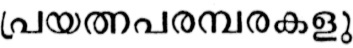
പ്രയത്നപരമ്പരകളു
